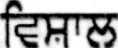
ਵਿਸ਼ਾਲ
